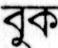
বুক
